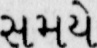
સમયે
